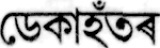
ডেকাহঁতৰ
